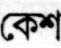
কেশ
